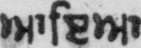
ਆਇਆ
